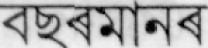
বছৰমানৰ
